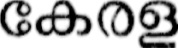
കേരള
